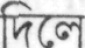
দিলে
